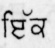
ਇੱਕ
